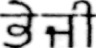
ਭੇਜੀ
